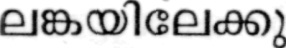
ലങ്കയിലേക്കു
